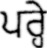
ਪਰ੍ਹੇ
